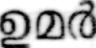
ഉമര്‍
